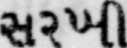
સરખી
